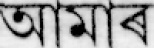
আমাৰ
